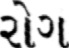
રોગ
